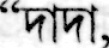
“দাদা,
